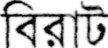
বিরাট
